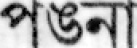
পঙনা
